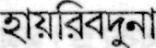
হায়রিবদুনা
